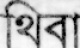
থিবা
